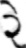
રે
